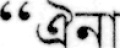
“ঐনা
